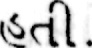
હતી.
